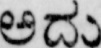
ಅದು
